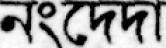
নংদেদা
